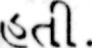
હતી.
